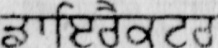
ਡਾਇਰੈਕਟਰ
